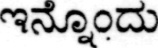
ಇನ್ನೊಂದು
